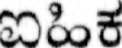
ಐಹಿಕ
